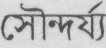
সৌন্দৰ্য্য
